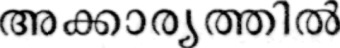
അക്കാര്യത്തില്‍
